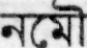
নমৌ
